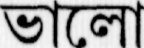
ভালো
